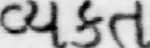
વ્યકત
